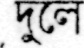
দুলে
